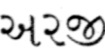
અરજી
